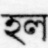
হল
